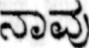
ನಾವು
